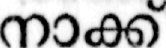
നാക്ക്
